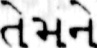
તેમને
